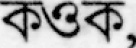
কওক,
